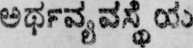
ಅರ್ಥವ್ಯವಸ್ಥೆಯ
